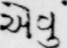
એવું
